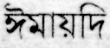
ঈমায়দি
